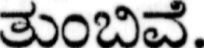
ತುಂಬಿವೆ.
